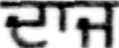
ਦਾਜ
